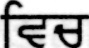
ਵਿਚ
